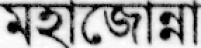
মহাজোন্না
